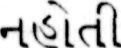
નહોતી
